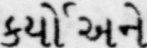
કર્યોઅને
